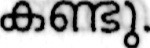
കണ്ടു.
